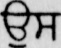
ਉਸ
